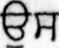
ਉਸ
